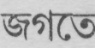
জগতে
